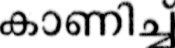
കാണിച്ച്
